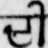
ਦੀ
